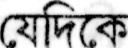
যেদিকে
